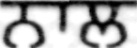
ਨਾਲ
